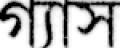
গ্যাস
